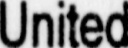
United
